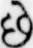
છે
